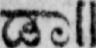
ಡಾ||
